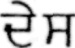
ਦੇਸ
